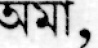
অমা,
